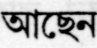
আছেন
